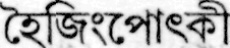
হৈজিংপোৎকী
